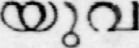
യുവ
